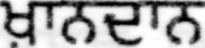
ਖ਼ਾਨਦਾਨ
